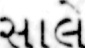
સાલે
